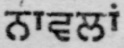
ਨਾਵਲਾਂ
